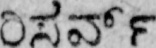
ರಿಸರ್ವ್
